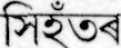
সিহঁতৰ
